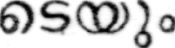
ടെയും
